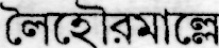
লৈহৌরমাল্লে
